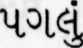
પગલું
